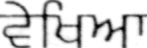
ਵੇਖਿਆ
